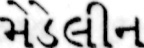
મેડેલીન
